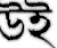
উই
